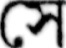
সে
